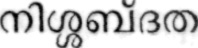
നിശ്ശബ്ദത
